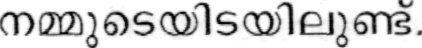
നമ്മുടെയിടയിലുണ്ട്.
